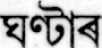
ঘণ্টাৰ
